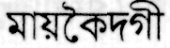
মায়কৈদগী
